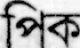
পিক
